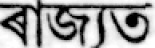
ৰাজ্যত
